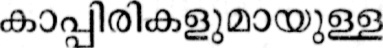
കാപ്പിരികളുമായുള്ള
